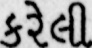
કરેલી
